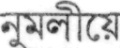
নুমলীয়ে
